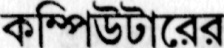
কম্পিউটারের
